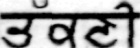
ਤੱਕਣੀ
